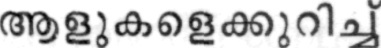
ആളുകളെക്കുറിച്ച്
